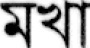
মখা
